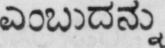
ಎಂಬುದನ್ನು
